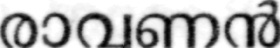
രാവണന്‍
